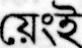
য়েংই
